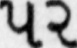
પર
